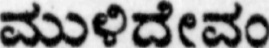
ಮುಳಿದೇವಂ
